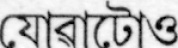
যোৱাটোও
